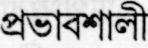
প্রভাবশালী
